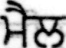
ਮੈਲ
